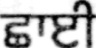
ਛਾਈ
